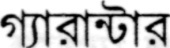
গ্যারান্টার
